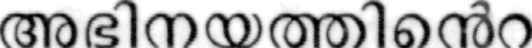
അഭിനയത്തിന്റെ
